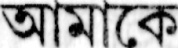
আমাকে
